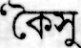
‘কৈসু
